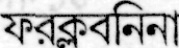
ফরক্লবনিনা
